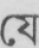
যে
